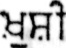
ਖ਼ੁਸ਼ੀ
